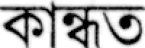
কান্ধত
